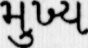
મુખ્ય
